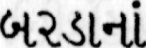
બરડાનાં
